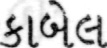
કાબેલ
